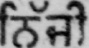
ਨਿੱਜੀ
